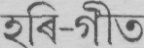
হৰি-গীত
